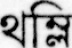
থম্লি
